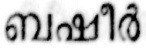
ബഷീര്‍
